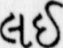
લઈ
